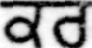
ਕਰ
